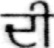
ਦੀ
